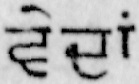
ਵੇਦਾਂ
